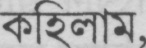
কহিলাম,
